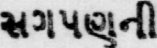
સગપણની
